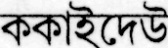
ককাইদেউ
